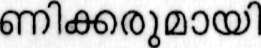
ണിക്കരുമായി
